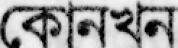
কোনখন
